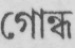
গোন্ধ
